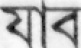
যাব
